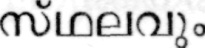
സ്ഥലവും
